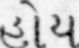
હોય
